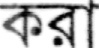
করা
